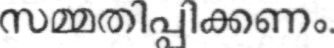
സമ്മതിപ്പിക്കണം.
